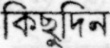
কিছুদিন
